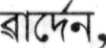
ৱার্দেন,
